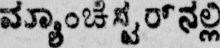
ಮ್ಯಾಂಚೆಸ್ಟರ್ನಲ್ಲಿ
